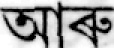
আৰু
